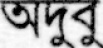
অদুবু
